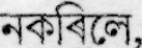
নকৰিলে,
